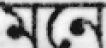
মনে
